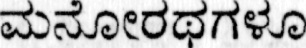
ಮನೋರಥಗಳೂ
